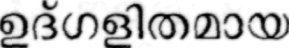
ഉദ്ഗളിതമായ
